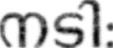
നടി:
